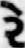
રે
